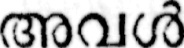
അവള്‍
